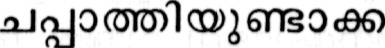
ചപ്പാത്തിയുണ്ടാക്ക
